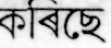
কৰিছে
